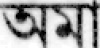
অমা
